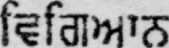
ਵਿਗਿਆਨ
